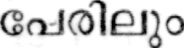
പേരിലും
